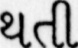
થતી
